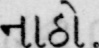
નાઠો.
